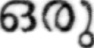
ഒരു
